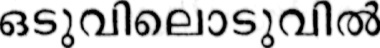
ഒടുവിലൊടുവില്‍
